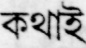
কথাই
